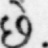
છે.
